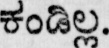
ಕಂಡಿಲ್ಲ.
